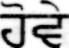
ਹੋਵੇ
